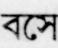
বসে
